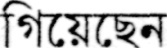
গিয়েছেন
